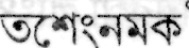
তশেংনমক
